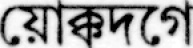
য়োক্কদগে
